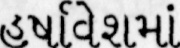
હર્ષાવેશમાં
